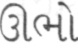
ઊભો
